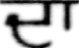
ਦਾ
